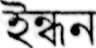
ইন্ধন
